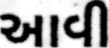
આવી
